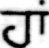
ਹਾਂ
